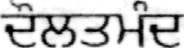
ਦੌਲਤਮੰਦ
